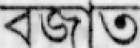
বজাত
